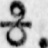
ಕಿ.
